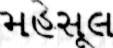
મહેસૂલ
